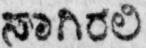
ನಾಗಿರಲಿ
